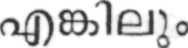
എങ്കിലും
